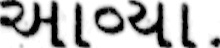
આવ્યા.
